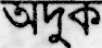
অদুক
